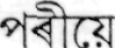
পৰীয়ে
